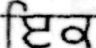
ਇਕ
